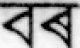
বৰ
